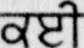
ਕਈ
